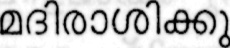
മദിരാശിക്കു
